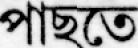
পাছতে
